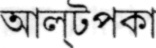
আল্‌টপকা
